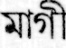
মাগী
